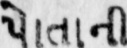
પોતાની
